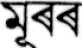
মূৰৰ
